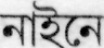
নাইনে
